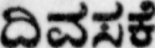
ದಿವಸಕೆ
